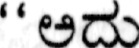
"ಅದು
